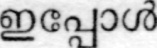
ഇപ്പോള്‍
